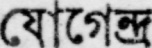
যোগেন্দ্র
